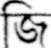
জি
